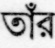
তাঁর
